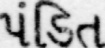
પંડિત
